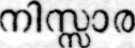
നിസ്സാര
